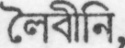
লৈবীনি,
